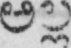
ಅಲ್ಲ
